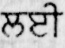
ਲਈ
